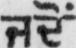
ਜਦੋਂ
